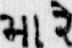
મારે
